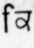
ਕਿ
